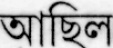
আছিল
